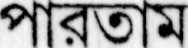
পারতাম
